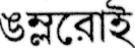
ঙম্লরোই
